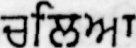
ਚਲਿਆ
